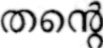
തന്റെ
